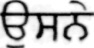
ਉਸਨੇ
